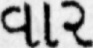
વાર
